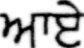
ਆਏ
